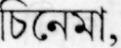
চিনেমা,
